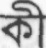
কী
